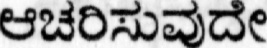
ಆಚರಿಸುವುದೇ
